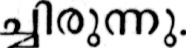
ച്ചിരുന്നു.
